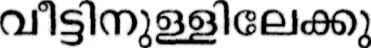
വീട്ടിനുള്ളിലേക്കു
